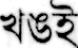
খঙই
